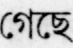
গেছে
